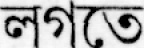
লগতে
